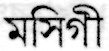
মসিগী
